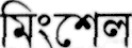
মিংশেল
